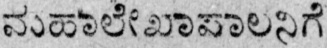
ಮಹಾಲೇಖಾಪಾಲನಿಗೆ
